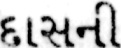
દાસની
